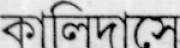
কালিদাসে
